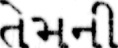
તેમની
